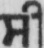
ਸੀ
